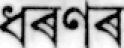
ধৰণৰ
